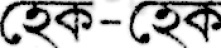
হেক-হেক
